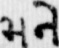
મને
